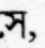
সে,
